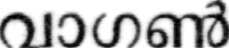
വാഗണ്‍
